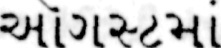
ઑગસ્ટમાં
